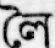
লৈ
